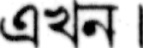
এখন।
